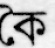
কৈ
